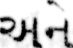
અને
